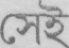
সেই
